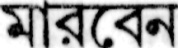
মারবেন
